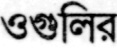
ওগুলির
